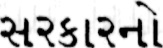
સરકારનો
